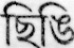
ছিঙি
